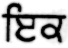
ਇਕ
